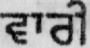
ਵਾਰੀ
